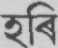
হৰি
